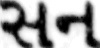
સન
